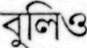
বুলিও
